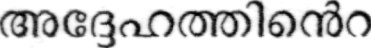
അദ്ദേഹത്തിന്റെ
